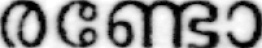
രണ്ടോ
